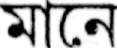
মানে
